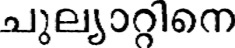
ചുല്യാറ്റിനെ
